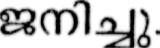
ജനിച്ചു.
